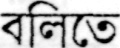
বলিতে
